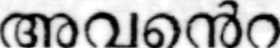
അവന്റെ
